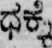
ಧಕ್ಕೆ
